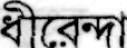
ধীরেন্দা
